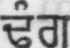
ਢੰਗ
